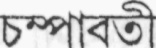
চম্পাবতী
